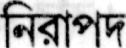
নিরাপদ
